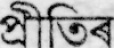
প্রীতিৰ
